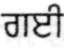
ਗਈ
